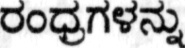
ರಂಧ್ರಗಳನ್ನು
